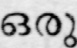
ഒരു
